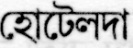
হোটেলদা
